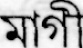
মাগী
